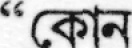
"কোন
